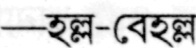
–হল্ল-বেহল্ল
